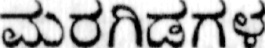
ಮರಗಿಡಗಳ
